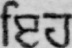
ਇਹ
